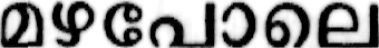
മഴപോലെ
